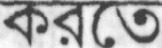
করতে
